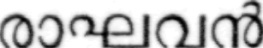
രാഘവന്‍
